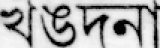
খঙদনা
